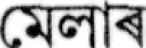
মেলাৰ
